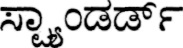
ಸ್ಟ್ಯಾಂಡರ್ಡ್
